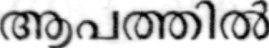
ആപത്തില്‍
